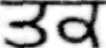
ਤਕ
